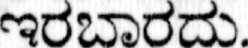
ಇರಬಾರದು.
